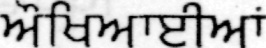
ਔਖਿਆਈਆਂ
